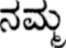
ನಮ್ಮ
